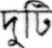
দুটি
